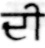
ਦੀ
